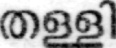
തള്ളി
